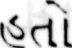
હતો
